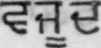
ਵਜੂਦ
